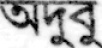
অদুবু
